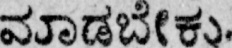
ಮಾಡಬೇಕು.
